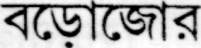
বড়োজোর
